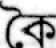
কৈ
